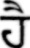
ਹੈ
